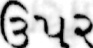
ઉપર
